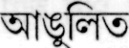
আঙুলিত
